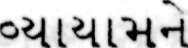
વ્યાયામને
